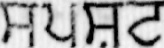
ਸਪਸ਼ਟ
